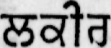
ਲਕੀਰ
